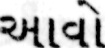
આવો
